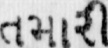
તમારી
